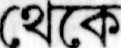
থেকে
